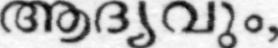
ആദ്യവും,
